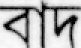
বাদ
